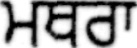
ਮਥਰਾ
